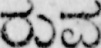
ರುವ
